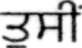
ਤੁਸੀਂ
